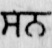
ਸਨ
